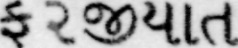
ફરજીયાત
